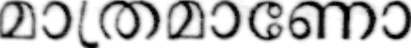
മാത്രമാണോ
